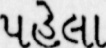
પહેલા
